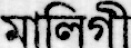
মালিগী
